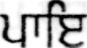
ਪਾਇ
